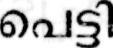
പെട്ടി
